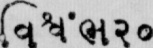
વિશ્વંભર.
